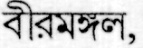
বীরমঙ্গল,
